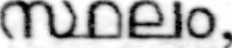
സ്ഥലം,
